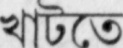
খাটতে
